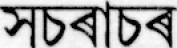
সচৰাচৰ
